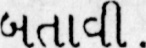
બતાવી.
